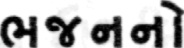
ભજનનો
